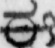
ಈ
